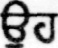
ਉਹ
